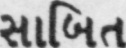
સાબિત
